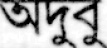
অদুবু
